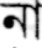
না
